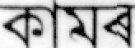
কামৰ
